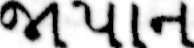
જાપાન
